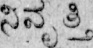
ನಿವೃತ್ತಿ
